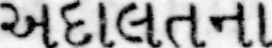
અદાલતના
